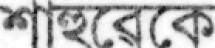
শাহুৱেকে
